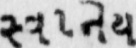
સ્વપ્નેય
